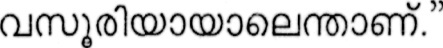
വസൂരിയായാലെന്താണ്."
